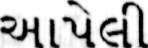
આપેલી
